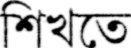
শিখতে
